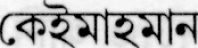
কেইমাহমান
